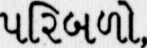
પરિબળો,
